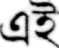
এই
